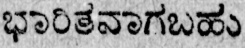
ಭಾರಿತವಾಗಬಹು
